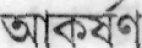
আকর্ষণ
